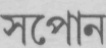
সপোন
